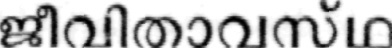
ജീവിതാവസ്ഥ
